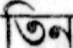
তিন
